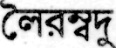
লৈরম্বদু
